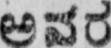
ಅವರ
